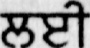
ਲਈ
